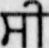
ਸੀ
